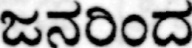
ಜನರಿಂದ
